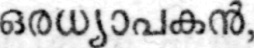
ഒരധ്യാപകന്‍,
